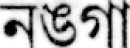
নঙগা
